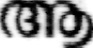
ആ
